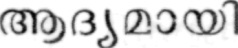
ആദ്യമായി
